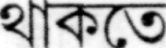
থাকতে
